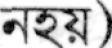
নহয়)
